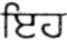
ਇਹ
